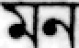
মন
